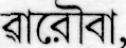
ৱারৌবা,
